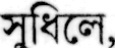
সুধিলে,
